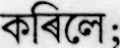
কৰিলে;
